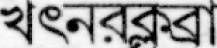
খৎনরক্লব্রা
